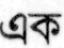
এক
